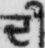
ਦੀ
